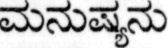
ಮನುಷ್ಯನು
